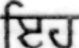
ਇਹ
